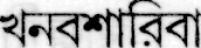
খনবশারিবা
